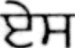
ਏਸ
